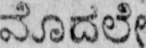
ಮೊದಲೇ
